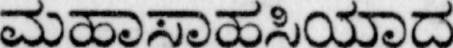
ಮಹಾಸಾಹಸಿಯಾದ
